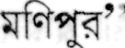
মণিপুর”
